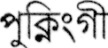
পুক্নিংগী
